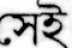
সেই
